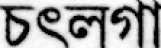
চৎলগা
